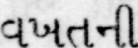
વખતની
